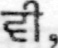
ਵੀ,
